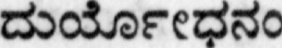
ದುರ್ಯೋಧನಂ
